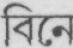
বিনে
